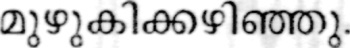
മുഴുകിക്കഴിഞ്ഞു.
